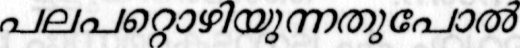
പലപറ്റൊഴിയുന്നതുപോല്‍
